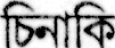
চিনাকি
